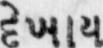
દેખાય
